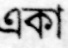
একা
